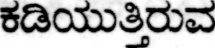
ಕಡಿಯುತ್ತಿರುವ
